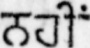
ਨਹੀਂ
